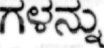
ಗಳನ್ನು
